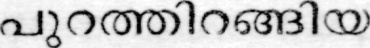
പുറത്തിറങ്ങിയ
